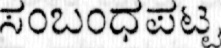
ಸಂಬಂಧಪಟ್ಟ
